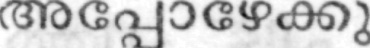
അപ്പോഴേക്കു
